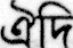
ঐদি
